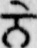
ਨੇ
